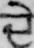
ਦੇ
